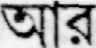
আর
